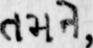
તમને,
